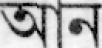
আন
